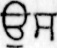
ਉਸ
